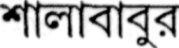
শালাবাবুর
